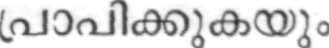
പ്രാപിക്കുകയും
